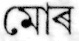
মোৰ
